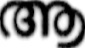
ആ
